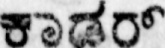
ಕಾಡರ್
